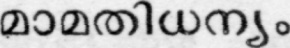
മാമതിധന്യം
